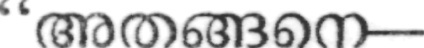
"അതങ്ങനെ-
